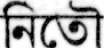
নিতৌ
